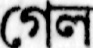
গেল
